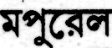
মপুরেল
